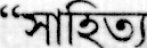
“সাহিত্য
